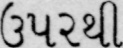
ઉપરથી
